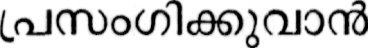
പ്രസംഗിക്കുവാന്‍
